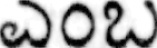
ಎಂಬ
